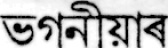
ভগনীয়াৰ
